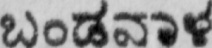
ಬಂಡವಾಳ
